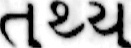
તથ્ય
